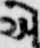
એ
